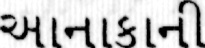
આનાકાની
